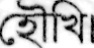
হৌখি।
